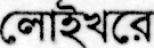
লোইখরে
